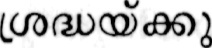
ശ്രദ്ധയ്ക്കു
